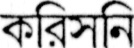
করিসনি
